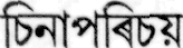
চিনাপৰিচয়
